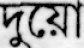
দুয়ো
